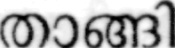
താങ്ങി
